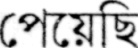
পেয়েছি
